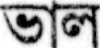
ভাল
